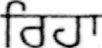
ਰਿਹਾ
